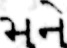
મને
